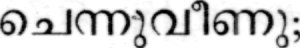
ചെന്നുവീണു;
